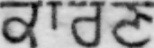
ਕਾਰਣ
